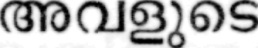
അവളുടെ
